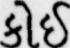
કોઈ
